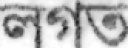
লগত
